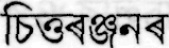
চিত্তৰঞ্জনৰ
